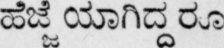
ಹೆಜ್ಜೆಯಾಗಿದ್ದರೂ
